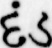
દંડ
